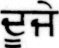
ਦੂਜੇ
